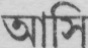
আসি
